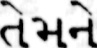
તેમને
